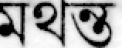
মথন্ত
